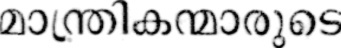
മാന്ത്രികന്മാരുടെ
